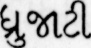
ધ્રુજાટી
